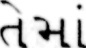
તેમાં
